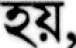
হয়,
